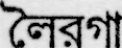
লৈরগা
